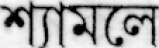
শ্যামলে
